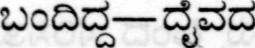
ಬಂದಿದ್ದ-ದೈವದ
